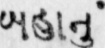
બહાનું
